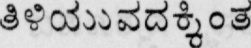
ತಿಳಿಯುವದಕ್ಕಿಂತ
